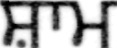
ਸ਼ਾਮ
